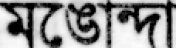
মঙোন্দা
